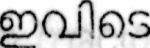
ഇവിടെ
